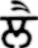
ਲੈ
